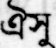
ঐসু
